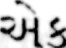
એક
